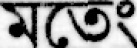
মতেং
